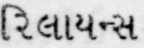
રિલાયન્સ
